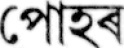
পোহৰ
